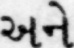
અને
